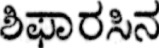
ಶಿಫಾರಸಿನ
